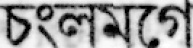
চংলমগে
